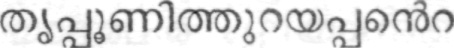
തൃപ്പൂണിത്തുറയപ്പന്റെ
